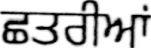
ਛਤਰੀਆਂ
